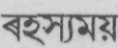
ৰহস্যময়
